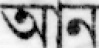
আন
